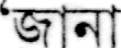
‘জানা
